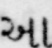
આ
